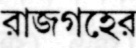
রাজগহের
